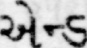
એન્ડ
